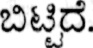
ಬಿಟ್ಟಿದೆ.
